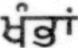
ਖੰਭਾਂ
